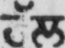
ਹੱਲ
